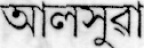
আলসুৱা
